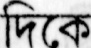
দিকে
